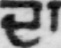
ਦਾ
